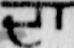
ਦਾ
